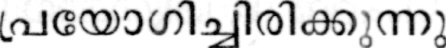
പ്രയോഗിച്ചിരിക്കുന്നു
